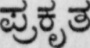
ಪ್ರಕೃತ
